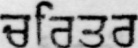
ਚਰਿਤਰ
